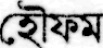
হৌফম
